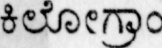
ಕಿಲೋಗ್ರಾಂ
